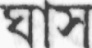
ঘাস
